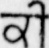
ਕੀ
